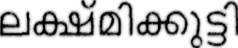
ലക്ഷ്മിക്കുട്ടി
